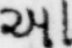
આ
